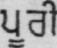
ਪੂਰੀ
